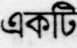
একটি
